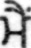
ਮੈਂ
